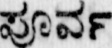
ಪೂರ್ವ
